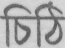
চিঠি
